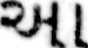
આ
